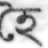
হৈ
